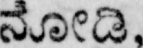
ನೋಡಿ,
